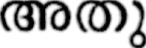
അതു
